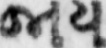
જાય
